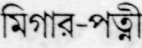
মিগার-পত্নী
